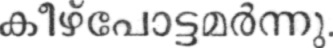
കീഴ്പോട്ടമര്‍ന്നു.
